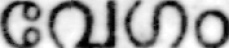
വേഗം
